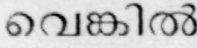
വെങ്കില്‍
